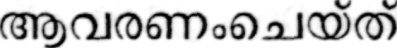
ആവരണംചെയ്ത്
